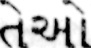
તેઓ
